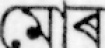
মোৰ
